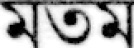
মতম
